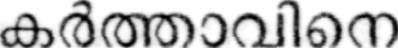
കര്‍ത്താവിനെ
